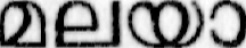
മലയാ
